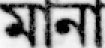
মানা
